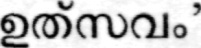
ഉത് സവം’
